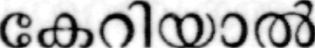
കേറിയാല്‍
